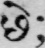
છે;
